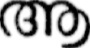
ആ
